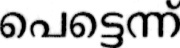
പെട്ടെന്ന്
